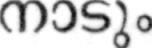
നാടും
